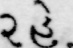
રહે.
